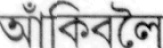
আঁকিবলৈ
